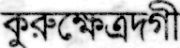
কুরুক্ষেত্রদগী
